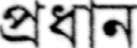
প্রধান
